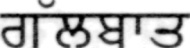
ਗੱਲਬਾਤ
